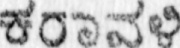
ಕರಾವಳಿ
